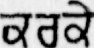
ਕਰਕੇ
